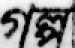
গল্প
